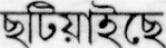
ছটিয়াইছে
